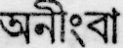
অনীংবা
